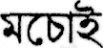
মচোই
